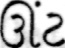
ઊંટ
